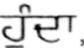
ਹੁੰਦਾ,
